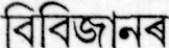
বিবিজানৰ
